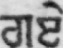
ਗਏ
